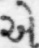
એ
